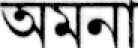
অমনা
